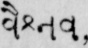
વૈશ્વનવ,
